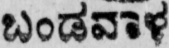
ಬಂಡವಾಳ
